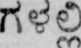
ಗಳಲ್ಲಿ
